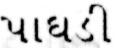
પાઘડી
